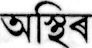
অস্হিৰ
